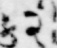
કરી
